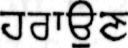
ਹਰਾਉਣ
